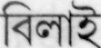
বিলাই
